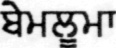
ਬੇਮਲੂਮਾ
